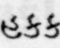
હક્ક
